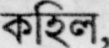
কহিল,
